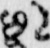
છૂટે
